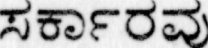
ಸರ್ಕಾರವು
